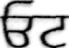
ਓਟ
